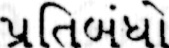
પ્રતિબંધો
